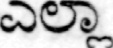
ಎಲ್ಲಾ
